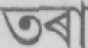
তৰা
